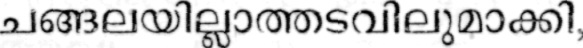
ചങ്ങലയില്ലാത്തടവിലുമാക്കി,
